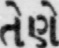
તેણે
